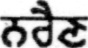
ਨਰੈਣ
